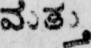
ಮತ್ತು
